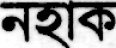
নহাক
